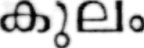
കുലം
